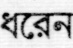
ধরেন
